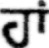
ਹਾਂ
